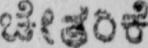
ಚೇತರಿಕೆ
